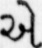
એ
